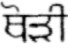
ਥੋੜੀ
